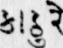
કાઠુરે
